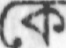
কে
